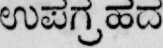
ಉಪಗ್ರಹದ
